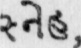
સ્નેહ,
